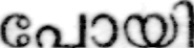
പോയി
